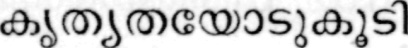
കൃത്യതയോടുകൂടി
